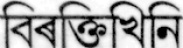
বিৰক্তিখিনি
